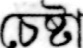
চেষ্টা
